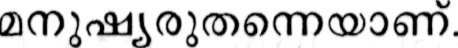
മനുഷ്യരുതന്നെയാണ്.
